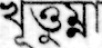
খূত্তুম্না
